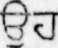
ਉਹ
